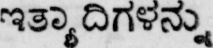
ಇತ್ಯಾದಿಗಳನ್ನು
